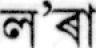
ল'ৰা
